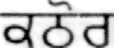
ਕਠੋਰ
